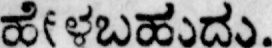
ಹೇಳಬಹುದು.
